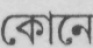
কোনে
